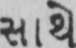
સાથે
